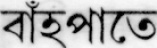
বাঁহপাতে
